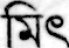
মিৎ
